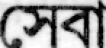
সেবা
